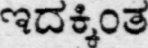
ಇದಕ್ಕಿಂತ
